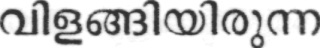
വിളങ്ങിയിരുന്ന
